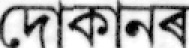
দোকানৰ
